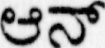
ಆನ್
